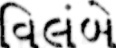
વિલંબે
